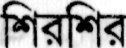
শিরশির
